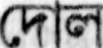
দোল
